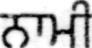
ਨਾਮੀ
